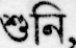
শুনি,
